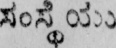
ಸಂಸ್ಥೆಯು
